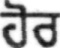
ਹੋਰ
